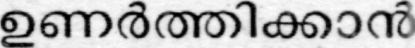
ഉണര്‍ത്തിക്കാന്‍
